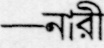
–নারী
